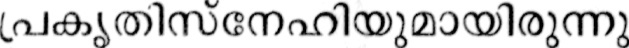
പ്രകൃതിസ്നേഹിയുമായിരുന്നു
